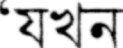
‘যখন
